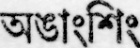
অঙাংশিং
